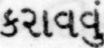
કરાવવું
